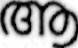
ആ
